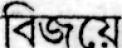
বিজয়ে
